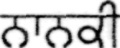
ਨਾਨਕੀ
